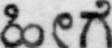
ಹೀಗೆ
